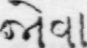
જોવા
